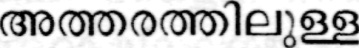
അത്തരത്തിലുള്ള
